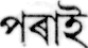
পৰাই
